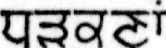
ਧੜਕਣਾਂ
